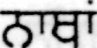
ਨਾਥਾਂ
